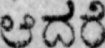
ಆದರೆ
